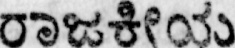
ರಾಜಕೀಯ
